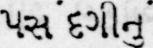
પસંદગીનું
